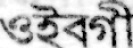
ওইবগী
